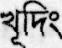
খূদিং
